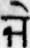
ਜੇ
